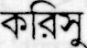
করিসু
